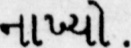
નાખ્યો.
